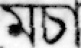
মচা
